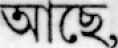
আছে,
